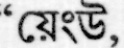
“য়েংউ,
